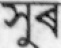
সুৰ
